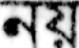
নয়
